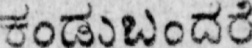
ಕಂಡುಬಂದರೆ
